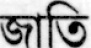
জাতি
